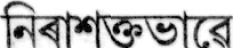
নিৰাশক্তভাৱে
